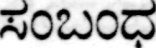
ಸಂಬಂಧ
